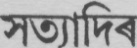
সত্যাদিৰ
